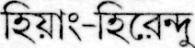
হিয়াং-হিরেন্দু
